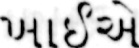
ખાઈએ
